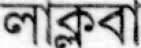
লাক্লবা
